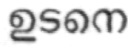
ഉടനെ
